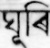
ঘূৰি
